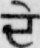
ਦੇ
